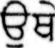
ਉਥੇ
